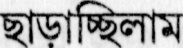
ছাড়াচ্ছিলাম
